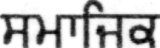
ਸਮਾਜਿਕ
